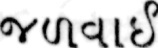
જળવાઈ
